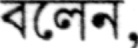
বলেন,
